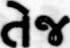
તેજ
